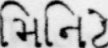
મિનિટે
